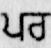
ਪਰ
